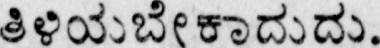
ತಿಳಿಯಬೇಕಾದುದು.
